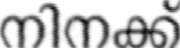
നിനക്ക്
